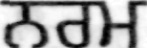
ਨਰਮ
